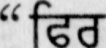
''ਫਿਰ
